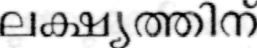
ലക്ഷ്യത്തിന്
